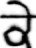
ਕੇ
